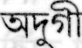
অদুগী
